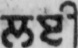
ਲਈ
